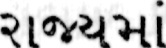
રાજ્યમાં
